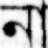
না
